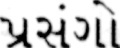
પ્રસંગો
